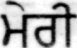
ਮੇਰੀ
